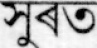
সুৰত
